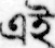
এই
